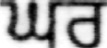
ਘਰ
